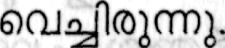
വെച്ചിരുന്നു.
